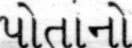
પોતાનો
